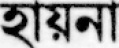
হায়না
